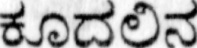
ಕೂದಲಿನ
